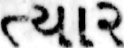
ત્યાર
